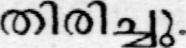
തിരിച്ചു.
